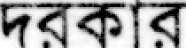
দরকার
